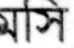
মসি
